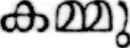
കമ്മു
